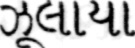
ઝૂલયા
